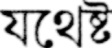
যথেষ্ট
